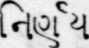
નિર્ણય
